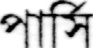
পার্সি
